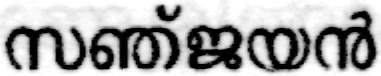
സഞ്ജയന്‍
